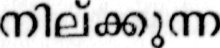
നില്ക്കുന്ന
